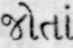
જોતાં
